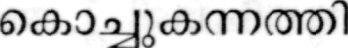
കൊച്ചുകന്നത്തി
